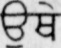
ਉਥੇ
